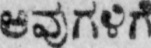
ಅವುಗಳಿಗೆ
